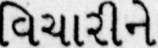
વિચારીને
